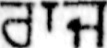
ਰਾਜ
